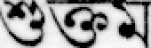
শুক্তম
